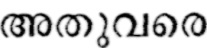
അതുവരെ
